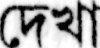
দেখা
